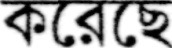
করেছে
